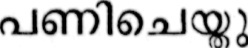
പണിചെയ്തു
